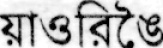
য়াওরিঙৈ
